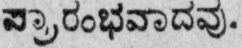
ಪ್ರಾರಂಭವಾದವು.
